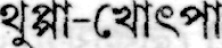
থুপ্পা-খোৎপা
